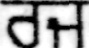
ਰਜ
